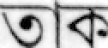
তাক
